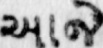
આજે
